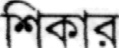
শিকার
